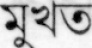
মুখত
